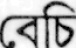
বেচি
